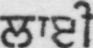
ਲਾਈ
